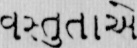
વસ્તુતાએ
